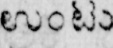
ಉಂಟು
